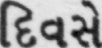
દિવસે
